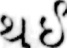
થઈ
